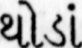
થોડાં
